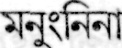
মনুংনিনা
